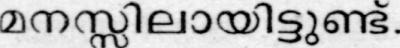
മനസ്സിലായിട്ടുണ്ട്.
